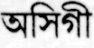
অসিগী
